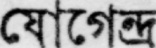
যোগেন্দ্র
